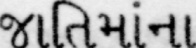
જાતિમાંના
